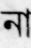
না
